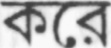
করে
